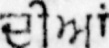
ਦੀਆਂ
